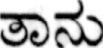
ತಾನು
